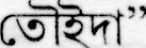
তৌইদা”
